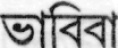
ভাবিবা
